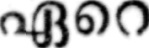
ഏറെ
